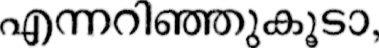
എന്നറിഞ്ഞുകൂടാ,
